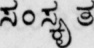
ಸಂಸ್ಕೃತ
